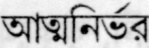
আত্মনির্ভর
